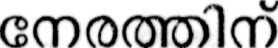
നേരത്തിന്
